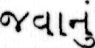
જવાનું
